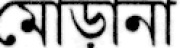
মোড়ানা
